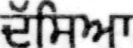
ਦੱਸਿਆ
